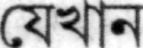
যেখান
